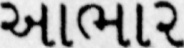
આભાર
